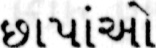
છાપાંઓ
